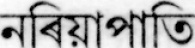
নৰিয়াপাতি
